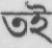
তই
